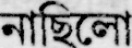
নাছিলো
